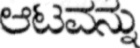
ಆಟವನ್ನು
